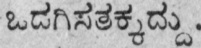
ಒದಗಿಸತಕ್ಕದ್ದು.
